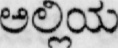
ಅಲ್ಲಿಯ
